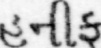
હનીફ
